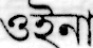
ওইনা
